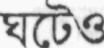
ঘটেও
